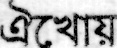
ঐখোয়
